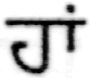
ਹਾਂ
